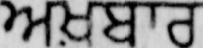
ਅਖ਼ਬਾਰ
